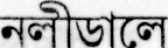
নলীডালে
